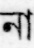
না
